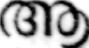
ആ
